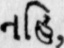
નહિ,
